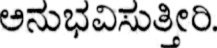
ಅನುಭವಿಸುತ್ತೀರಿ.
